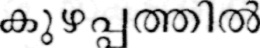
കുഴപ്പത്തില്‍
